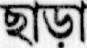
ছাড়া
